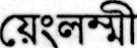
য়েংলম্মী
